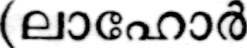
(ലാഹോര്‍
